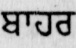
ਬਾਹਰ
